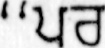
''ਪਰ
